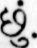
છું.
